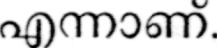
എന്നാണ്.
